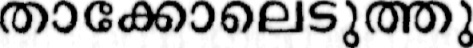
താക്കോലെടുത്തു
